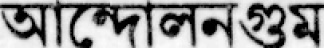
আন্দোলনগুম
